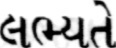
લભ્યતે
